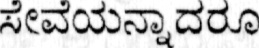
ಸೇವೆಯನ್ನಾದರೂ
